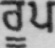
ਰੂਪ
